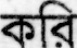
করি
